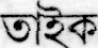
তাইক
